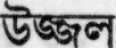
উজ্জল
